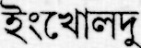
ইংখোলদু
